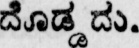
ದೊಡ್ಡದು.
